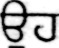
ਉਹ
